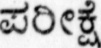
ಪರೀಕ್ಷೆ
